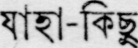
যাহা-কিছু
